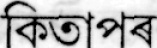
কিতাপৰ
